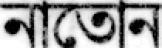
নাতোন
